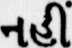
નહીં
